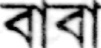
বাবা
